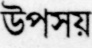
উপসয়
